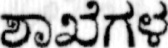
ಶಾಖೆಗಳ
